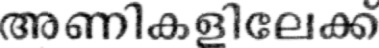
അണികളിലേക്ക്
